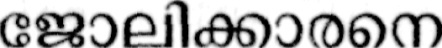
ജോലിക്കാരനെ
